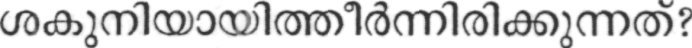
ശകുനിയായിത്തീര്‍ന്നിരിക്കുന്നത്?
